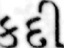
કદી
